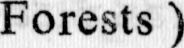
Forests)
